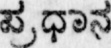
ಪ್ರಧಾನ
